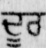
ਦੂਰ
